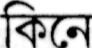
কিনে
